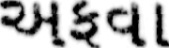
અફવા
